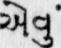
એવું
